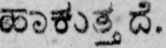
ಹಾಕುತ್ತದೆ.
